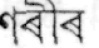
শৰীৰ
